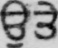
ਉਤੇ
